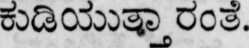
ಕುಡಿಯುತ್ತಾರಂತೆ.
